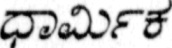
ಧಾರ್ಮಿಕ
